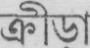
ক্ৰীড়া
